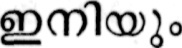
ഇനിയും
